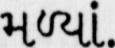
મળ્યાં.
